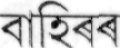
বাহিৰৰ
